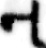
ન
